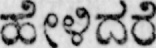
ಹೇಳಿದರೆ
